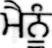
ਮੈਨੂੰ
